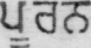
ਪੂਰਨ
